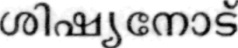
ശിഷ്യനോട്
